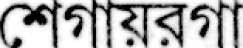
শেগায়রগা
